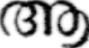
ആ
